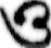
ও
